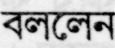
বললেন
